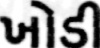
ખોડી
